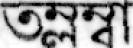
তম্লম্বা
